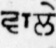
ਵਾਲੇ
